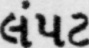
લંપટ
